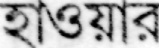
হাওয়ার
